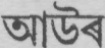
আউৰ
